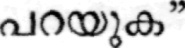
പറയുക”
